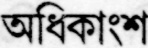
অধিকাংশ
